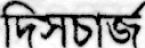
দিসচার্জ
